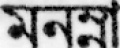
মনম্না
